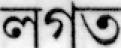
লগত
